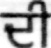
ਦੀ
